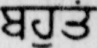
ਬਹੁਤ
